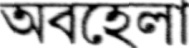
অবহেলা
